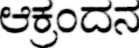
ಆಕ್ರಂದನ
